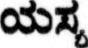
ಯಸ್ಯ
